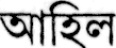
আহিল
